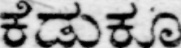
ಕೆಡುಕೂ
